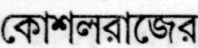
কোশলরাজের
